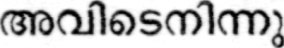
അവിടെനിന്നു
